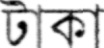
টাকা
